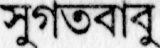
সুগতবাবু
